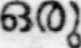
ഒരു
